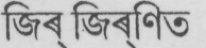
জিৰ্‌জিৰ্‌ণিত
